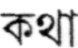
কথা
